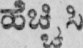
ಹೆಚ್ಚಿಸಿ
